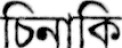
চিনাকি
